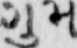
ગુમ
